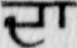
ਦਾ
